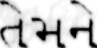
તેમને
